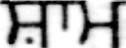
ਸ਼ਾਮ
